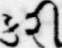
કરી
